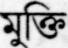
মুক্তি
